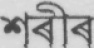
শৰীৰ
